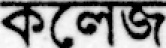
কলেজ
